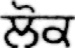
ਲੋਕ
